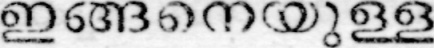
ഇങ്ങനെയുള്ള
